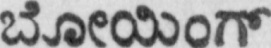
ಬೋಯಿಂಗ್
